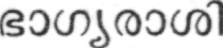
ഭാഗ്യരാശി
